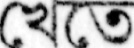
খেতে
